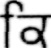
ਕਿ
